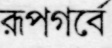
রূপগর্বে
